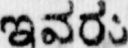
ಇವರು
